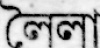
লৈলা
